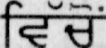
ਵਿੱਚੋਂ
